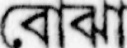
বোঝা
